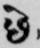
છે,
